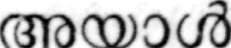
അയാള്‍
